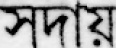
সদায়
